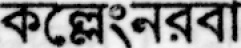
কল্লেংনরবা
